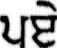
ਪਏ
